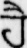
ਹੈ
